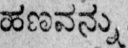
ಹಣವನ್ನು
